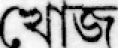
খোজ
